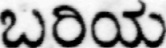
ಬರಿಯ
